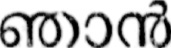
ഞാന്‍
